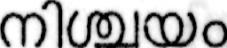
നിശ്ചയം
